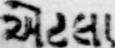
એટલા
